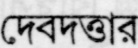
দেবদত্তার
